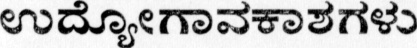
ಉದ್ಯೋಗಾವಕಾಶಗಳು
